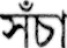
সঁচা
